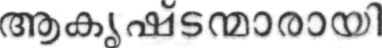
ആകൃഷ്ടന്മാരായി
